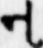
ન
